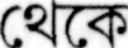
থেকে
